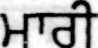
ਮਾਰੀ
